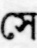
সে
